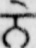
ਨੇ
